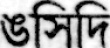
ঙসিদি
